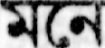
মনে
